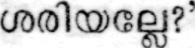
ശരിയല്ലേ?’
